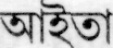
আইতা
